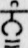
ਨੂੰ
